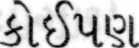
કોઈપણ
